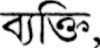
ব্যক্তি,
